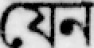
যেন
